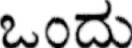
ಒಂದು
